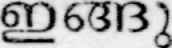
ഇങ്ങു
